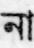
না
